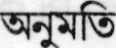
অনুমতি
